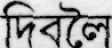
দিবলৈ
